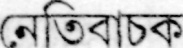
নেতিবাচক
